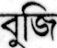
বুজি
